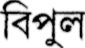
বিপুল
